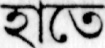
হাতে
